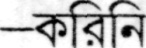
-করিনি
